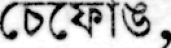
চেফোঙ,
